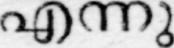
എന്നു
